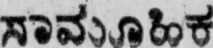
ಸಾಮೂಹಿಕ
